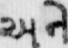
અને
